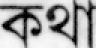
কথা
